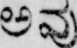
ಅವು
